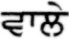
ਵਾਲੇ
